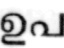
ഉപ
